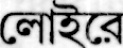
লোইরে
